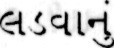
લડવાનું
